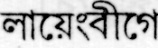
লায়েংবীগে
